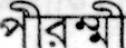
পীরম্মী
